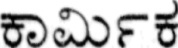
ಕಾರ್ಮಿಕ
